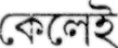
কেলেই
